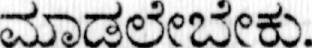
ಮಾಡಲೇಬೇಕು.
